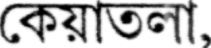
কেয়াতলা,
